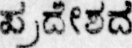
ಪ್ರದೇಶದ
